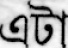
এটা
